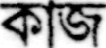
কাজ
